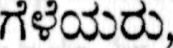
ಗೆಳೆಯರು,
